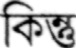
কিন্তু
